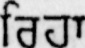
ਰਿਹਾ
